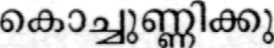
കൊച്ചുണ്ണിക്കു
